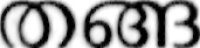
തങ്ങ
